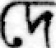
দে
